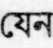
যেন
